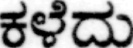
ಕಳೆದು
